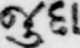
જુદા
